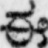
ಈ
